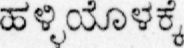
ಹಳ್ಳಿಯೊಳಕ್ಕೆ
